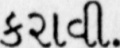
કરાવી.
